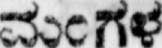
ಮಂಗಳ
